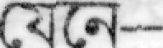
যেনে-
